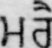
ਮਰੈ
